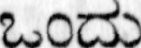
ಒಂದು
